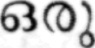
ഒരു
